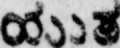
ಯುತ
